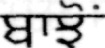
ਬਾਝੋਂ
